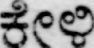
ಕೇಳಿ
